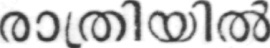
രാത്രിയില്‍
